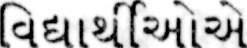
વિદ્યાર્થીઓએ
